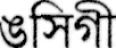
ঙসিগী
